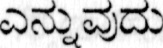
ಎನ್ನುವುದು
